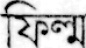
ফিল্ম
